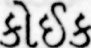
કોઈક
